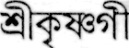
শ্রীকৃষ্ণগী
